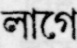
লাগে
